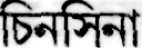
চিনসিনা
